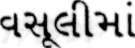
વસૂલીમાં
